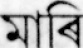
মাৰি
